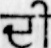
ਦੀ
